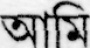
আমি
